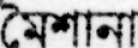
মৈশানা
